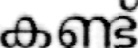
കണ്ട്
